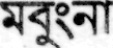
মবুংনা
